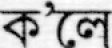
ক'লে
